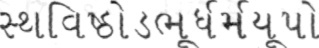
સ્થવિષ્ઠોડભૂર્ધર્મયૂપો
